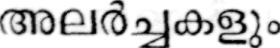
അലര്‍ച്ചകളും
